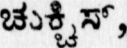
ಚುಕ್ಚಿಸ್,
